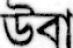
উবা
